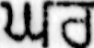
ਘਰ
